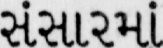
સંસારમાં
